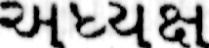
અધ્યક્ષ
